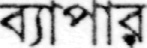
ব্যাপার
